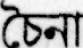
চৈনা
